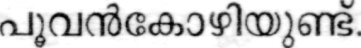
പൂവന്‍കോഴിയുണ്ട്.
